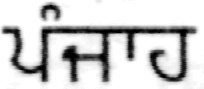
ਪੰਜਾਹ
